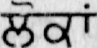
ਲੋਕਾਂ
